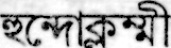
হুন্দোক্লম্মী
